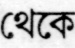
থেকে
